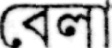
বেলা
